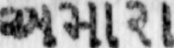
અમારા
